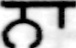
ਨਾ
